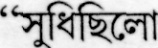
"সুধিছিলো
